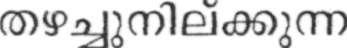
തഴച്ചുനില്ക്കുന്ന
